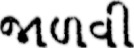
જાળવી
